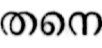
തനെ
